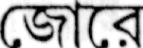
জোরে
